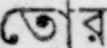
তোর
